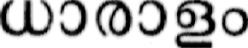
ധാരാളം
